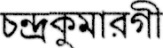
চন্দ্রকুমারগী
